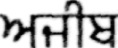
ਅਜੀਬ
